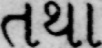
તથા
